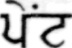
ਪੇਂਟ
